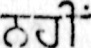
ਨਹੀਂ
